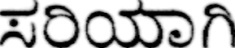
ಸರಿಯಾಗಿ
